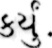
કર્યું.
